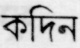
কদিন
